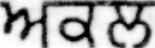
ਅਕਲ
